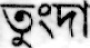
তুংদা
